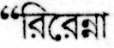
“রিবেন্না
